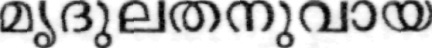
മൃദുലതനുവായ
